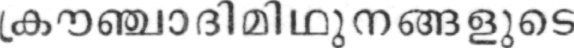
ക്രൗഞ്ചാദിമിഥുനങ്ങളുടെ
